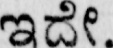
ಇದೇ.
